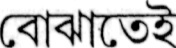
বোঝাতেই
